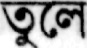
তুলে
